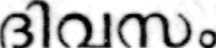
ദിവസം
